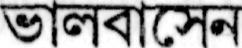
ভালবাসেন
